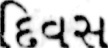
દિવસ
